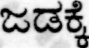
ಜಡಕ್ಕೆ
